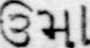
ઉમા
